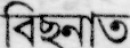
বিছনাত
